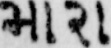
મારા
